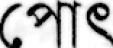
পোৎ
